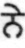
ਨੇ
